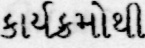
કાર્યક્રમોથી
